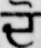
ਦੋ
